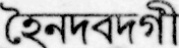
হৈনদবদগী
